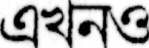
এখনও
